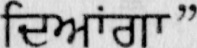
ਦਿਆਂਗਾ''
